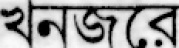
খনজরে
